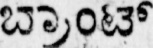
ಬ್ರಾಂಟ್
